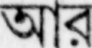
আর
